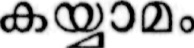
കയ്യാമം
